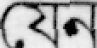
যেন
